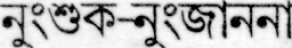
নুংশুক-নুংজাননা
